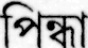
পিন্ধা
